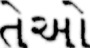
તેઓ
